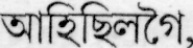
আহিছিলগৈ,
